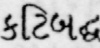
કટિબદ્દ
